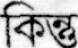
কিন্তু
